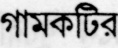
গামকটির
